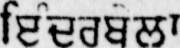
ਇੰਦਰਬੇਲਾ
